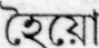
হৈয়ো
